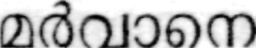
മര്‍വാനെ
